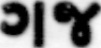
ગજ
